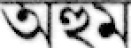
অহুম
